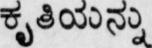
ಕೃತಿಯನ್ನು
